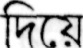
দিয়ে
